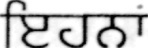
ਇਹਨਾਂ
